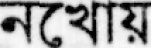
নখোয়
